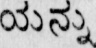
ಯನ್ನು
